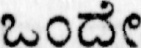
ಒಂದೇ
